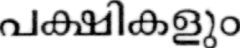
പക്ഷികളും
